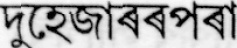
দুহেজাৰৰপৰা
